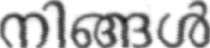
നിങ്ങള്‍
